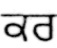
ਕਰ
